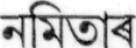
নমিতাৰ
